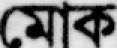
মোক
